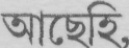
আছেহি,
